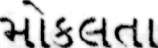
મોકલતા
